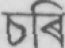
চৰি
